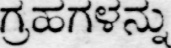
ಗ್ರಹಗಳನ್ನು
